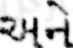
અને
